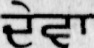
ਦੇਵਾ
